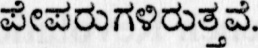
ಪೇಪರುಗಳಿರುತ್ತವೆ.
